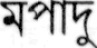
মপাদু
